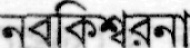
নবকিশ্বরনা
